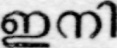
ഇനി
